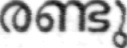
രണ്ടു
